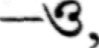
-ও,
